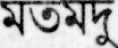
মতমদু
